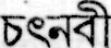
চৎনবী
